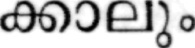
ക്കാലും
